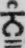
ਨੂੰ
